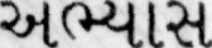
અભ્યાસ
